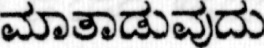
ಮಾತಾಡುವುದು
